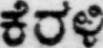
ಕೆರಳಿ
